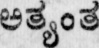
ಅತ್ಯಂತ
